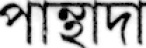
পান্থাদা
